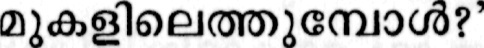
മുകളിലെത്തുമ്പോള്‍?’
